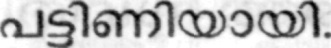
പട്ടിണിയായി.
